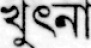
খুৎনা
